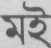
মই
